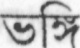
ভঙ্গি
